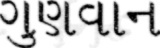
ગુણવાન
